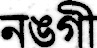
নঙগী
